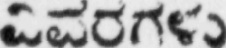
ವಿವರಗಳು
